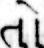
તો
